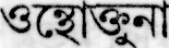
ওন্থোক্তুনা
